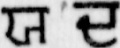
ਯਾਦ
